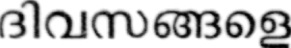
ദിവസങ്ങളെ
